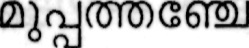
മുപ്പത്തഞ്ചേ
